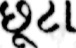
છૂટા
